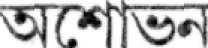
অশোভন
